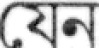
যেন
